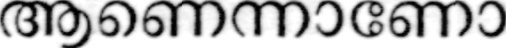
ആണെന്നാണോ
